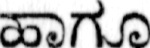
ಹಾಗೂ
